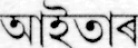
আইতাৰ
